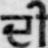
ਦੀ
